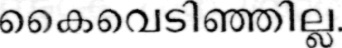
കൈവെടിഞ്ഞില്ല.
